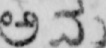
ಅದು
